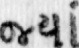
જ્યાં
